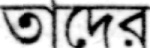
তাদের
